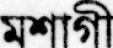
মশাগী
